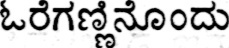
ಓರೆಗಣ್ಣಿನೊಂದು
